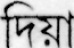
দিয়া
